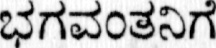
ಭಗವಂತನಿಗೆ
